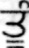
ਤੂੰ
